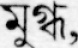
মুগ্ধ,
